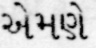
એમણે
